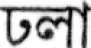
ঢলা
